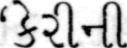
'કેરીની
